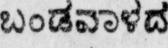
ಬಂಡವಾಳದ
